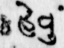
કહેવું
